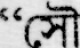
"সৌ
